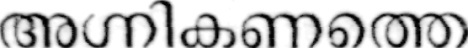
അഗ്നികണത്തെ
